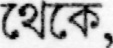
থেকে,
